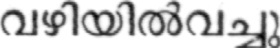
വഴിയില്‍വച്ചു
